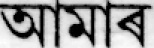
আমাৰ
